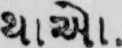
થાઓ.
